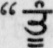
''ਤੂੰ
